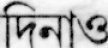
দিনাও
